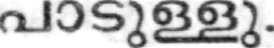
പാടുള്ളു.
